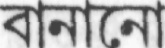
বানানো
